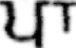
ਪਾ
